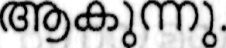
ആകുന്നു.
